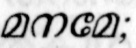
മനമേ;
